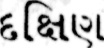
દક્ષિણ
